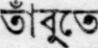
তাঁবুতে
